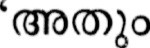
‘അതും
